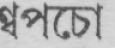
শ্বপচো
